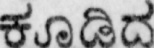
ಕೂಡಿದ
